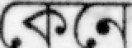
কেনে
